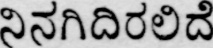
ನಿನಗಿದಿರಲಿದೆ
